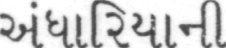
અંધારિયાની
